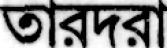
তারদরা
